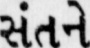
સંતને
